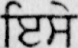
ਇਸੇ
